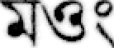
মওং
